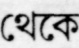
থেকে
